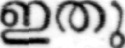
ഇതു
